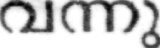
വന്നു
